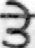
ਤੇ
